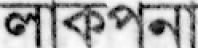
লাকপনা
